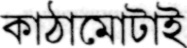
কাঠামোটাই
